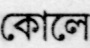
কোলে
